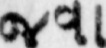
જવા
